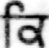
ਕਿ
